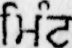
ਮਿੰਟ
